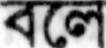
বলে
